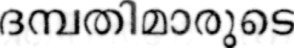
ദമ്പതിമാരുടെ
